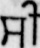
ਸੀ
